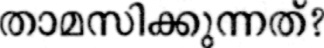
താമസിക്കുന്നത്?
